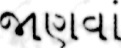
જાણવાં
